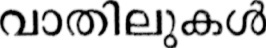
വാതിലുകള്‍
